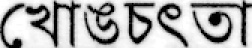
খোঙচৎতা
